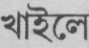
খাইলে
